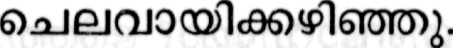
ചെലവായിക്കഴിഞ്ഞു.
